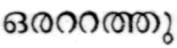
ഒരററത്തു
